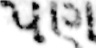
પણ
